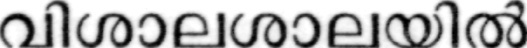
വിശാലശാലയില്‍
